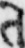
તે
